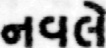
નવલે
